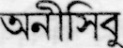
অনীসিবু
